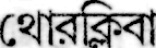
থোরক্লিবা
